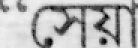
"সেয়া
